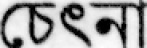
চেৎনা
